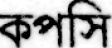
কপসি
